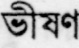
ভীষণ
